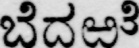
ಬೆದಱೆ
